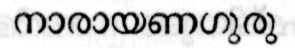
നാരായണഗുരു
